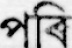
পৰি
